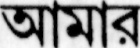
আমার
